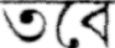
তবে
